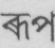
ৰূপ
